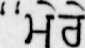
''ਮੇਰੇ
